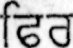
ਫਿਰ
